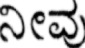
ನೀವು
